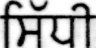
ਸਿੱਧੀ
